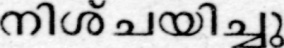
നിശ്ചയിച്ചു
